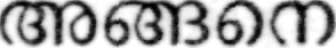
അങ്ങനെ
